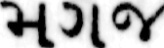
મગજ
